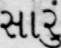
સારું
